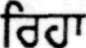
ਰਿਹਾ
